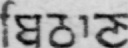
ਬਿਠਾਣ
